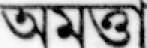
অমত্তা
